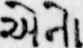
એનો
